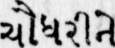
ચૌધરીને
